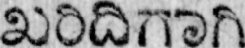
ಖರಿದಿಗಾಗಿ
